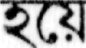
হয়ে
